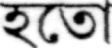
হতো
